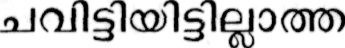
ചവിട്ടിയിട്ടില്ലാത്ത
